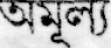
অমূল্য
